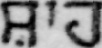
ਸ਼ਾਹ
